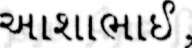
આશાભાઈ,
